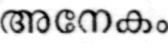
അനേകം
